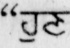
''ਹੁਣ
